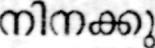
നിനക്കു
